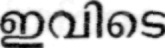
ഇവിടെ
